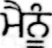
ਮੈਨੂੰ
